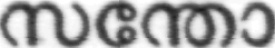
സന്തോ
